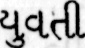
યુવતી
